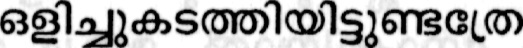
ഒളിച്ചുകടത്തിയിട്ടുണ്ടത്രേ
